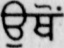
ਉਥੋਂ
